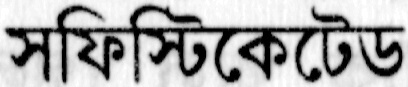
সফিস্টিকেটেড
